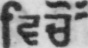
ਵਿਚੋਂ
